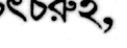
চৎচরুই,
